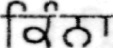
ਕਿੰਨਾ
